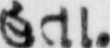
હતા.
